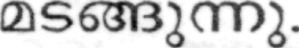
മടങ്ങുന്നു.
